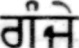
ਗੰਜੇ
